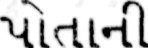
પોતાની
